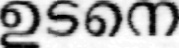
ഉടനെ
